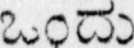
ಒಂದು
